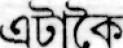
এটাকৈ
